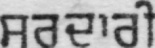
ਸਰਦਾਰੀ
